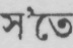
স'তে
